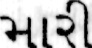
મારી
